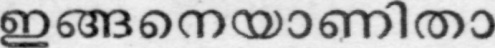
ഇങ്ങനെയാണിതാ
